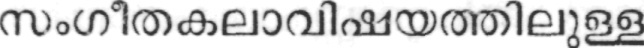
സംഗീതകലാവിഷയത്തിലുള്ള
